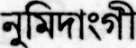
নুমিদাংগী
